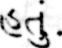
હતું.
